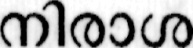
നിരാശ
